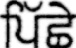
ਪਿੱਛੇ
